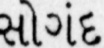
સોગંદ
